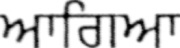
ਆਗਿਆ
